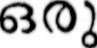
ഒരു
